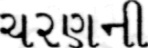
ચરણની
